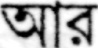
আর
